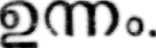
ഉന്നം.
